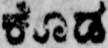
ಕೊಡ
